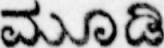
ಮೂಡಿ
